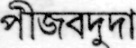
পীজবদুদা
